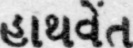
હાથવેંત
